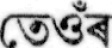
তেওঁৰ
